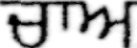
ਚਾਅ
